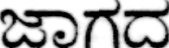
ಜಾಗದ
